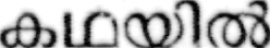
കഥയില്‍
